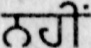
ਨਹੀਂ
